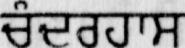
ਚੰਦਰਹਾਸ
